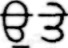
ਉਤੇ
